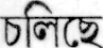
চলিছে
